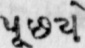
પૂછ્યે
